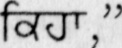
ਕਿਹਾ,''
